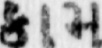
કામ
